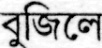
বুজিলে
